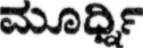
ಮೂರ್ಧ್ನಿ
